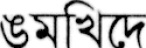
ঙমখিদে
